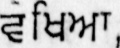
ਵੇਖਿਆ,
